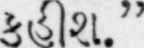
કહીશ."
